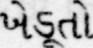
ખેડૂતો
